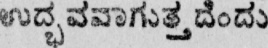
ಉದ್ಭವವಾಗುತ್ತದೆಂದು
